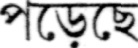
পড়েছে
